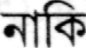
নাকি
